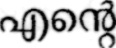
എന്റെ
